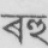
ৰহু
